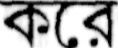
করে
